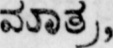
ಮಾತ್ರ,
